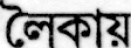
লৈকায়
